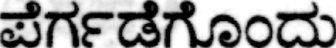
ಪೆರ್ಗಡೆಗೊಂದು
